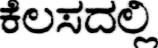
ಕೆಲಸದಲ್ಲಿ
